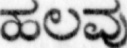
ಹಲವು
